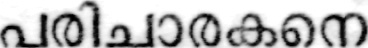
പരിചാരകനെ
